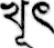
খূৎ
